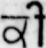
ਕੀ
